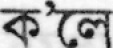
ক'লে
